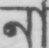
না
